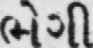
ભેગી
